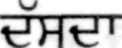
ਦੱਸਦਾ
